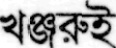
খঞ্জরুই
